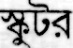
স্কুটর
